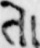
તો
